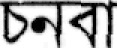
চনবা
